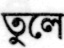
তুলে
